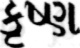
કૃષ્ણ
